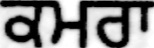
ਕਮਰਾ
